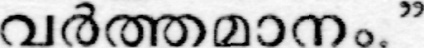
വര്‍ത്തമാനം.''
